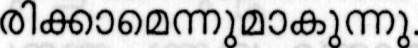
രിക്കാമെന്നുമാകുന്നു.
